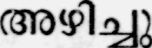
അഴിച്ചു
